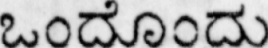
ಒಂದೊಂದು
